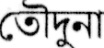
তৌদুনা
